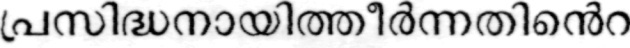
പ്രസിദ്ധനായിത്തീര്‍ന്നതിന്റെ
